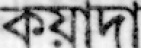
কয়াদা
